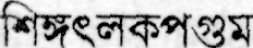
শিঙ্গৎলকপগুম
